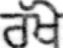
ਰੱਖੇ
